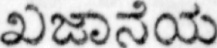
ಖಜಾನೆಯ
